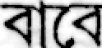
বাবে
